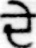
ਦੇ
